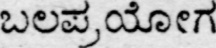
ಬಲಪ್ರಯೋಗ
